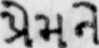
પ્રેમને
